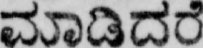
ಮಾಡಿದರೆ
